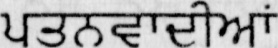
ਪਤਨਵਾਦੀਆਂ
